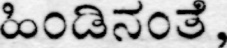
ಹಿಂಡಿನಂತೆ,
